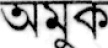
অমুক
